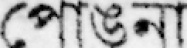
পোঙনা
